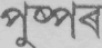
পুষ্পৰ
